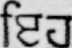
ਇਹ
